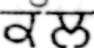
ਕੱਲ
